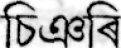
চিঞৰি
